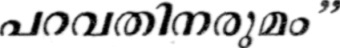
പറവതിനരുമം"
